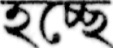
হচ্ছে
